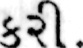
કરી.
